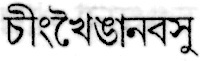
চীংখৈঙানবসু
